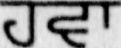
ਹਵਾ
